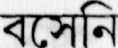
বসেনি
